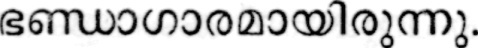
ഭണ്ഡാഗാരമായിരുന്നു.
